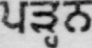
ਪੜ੍ਹਨ
